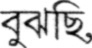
বুঝেছি,
